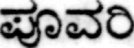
ಪೂವರಿ
